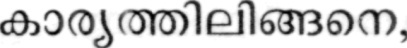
കാര്യത്തിലിങ്ങനെ,
